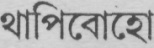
থাপিবোহো
